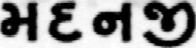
મદનજી
